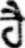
ਹੈ
